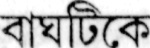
বাঘটিকে
